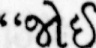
"જોઈ
